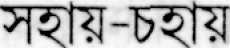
সহায়-চহায়
